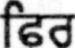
ਫਿਰ
